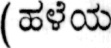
(ಹಳೆಯ
